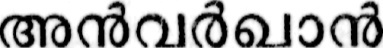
അന്‍വര്‍ഖാന്‍
